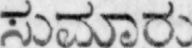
ಸುಮಾರು
